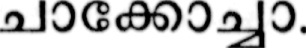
ചാക്കോച്ചാ.
